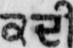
ਕਦੀ
